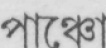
পাঞ্চো
